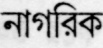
নাগরিক
